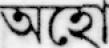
অহো
